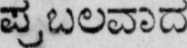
ಪ್ರಬಲವಾದ
